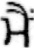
ਮੈਂ
